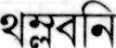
থম্লবনি
